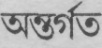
অন্তৰ্গত
